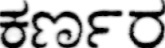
ಕರ್ಣರ
